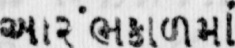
આરંભકાળમાં
